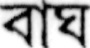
বাঘ
